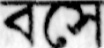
বসে
